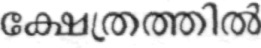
ക്ഷേത്രത്തില്‍
